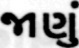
જાણું
